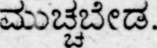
ಮುಚ್ಚಬೇಡ.
